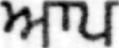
ਆਪ
